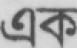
এক
